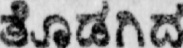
ತೊಡಗಿದ
